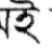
মই
